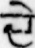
ਦੇ
